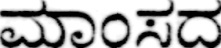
ಮಾಂಸದ
